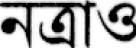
নত্রাও
